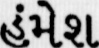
હંમેશ
